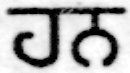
ਹਨ
